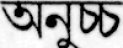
অনুচ্চ
